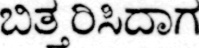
ಬಿತ್ತರಿಸಿದಾಗ
